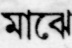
মাঝে
